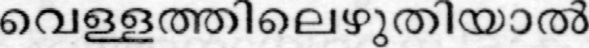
വെള്ളത്തിലെഴുതിയാല്‍
